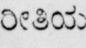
ರೀತಿಯ
